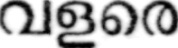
വളരെ
